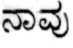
ನಾವು
